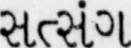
સત્સંગ
